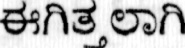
ಈಗಿತ್ತಲಾಗಿ
